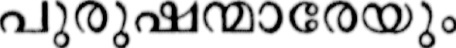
പുരുഷന്മാരേയും
